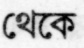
থেকে
